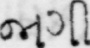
જાગી
